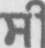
ਸੀ
